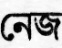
নেজ
